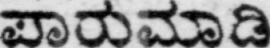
ಪಾರುಮಾಡಿ
